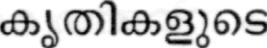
കൃതികളുടെ
